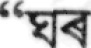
"ঘৰ
